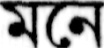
মনে
